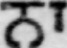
ਨਾ
